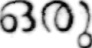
ഒരു
